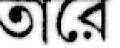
তারে
